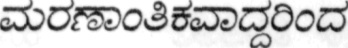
ಮರಣಾಂತಿಕವಾದ್ದರಿಂದ
